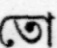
তো
